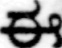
ಈ
